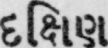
દક્ષિણ
